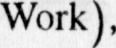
Work),
